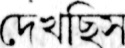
দেখছিস
